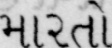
મારતો
